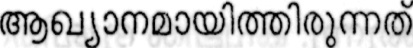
ആഖ്യാനമായിത്തിരുന്നത്
